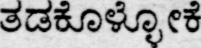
ತಡಕೊಳ್ಳೋಕೆ
